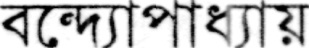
বন্দ্যোপাধ্যায়
